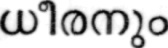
ധീരനും
